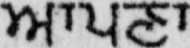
ਆਪਣਾ
